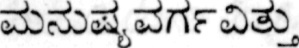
ಮನುಷ್ಯವರ್ಗವಿತ್ತು
